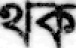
থক
